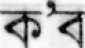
ক'ব
